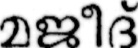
മജീദ്
